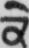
ਕੇ
